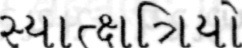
સ્યાત્ક્ષત્રિયો
